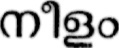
നീളം
